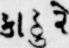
કાઠુરે
